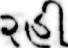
રહી
